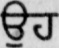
ਉਹ
